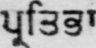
ਪ੍ਰਤਿਭਾ
